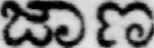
ಜಾಣ
